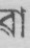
ৱা
